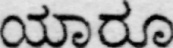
ಯಾರೂ
